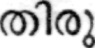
തിരു
